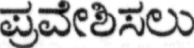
ಪ್ರವೇಶಿಸಲು
